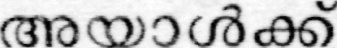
അയാള്‍ക്ക്
